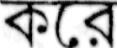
করে
